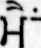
ਮੈਂ
